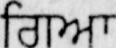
ਗਿਆ
